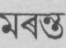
মৰন্ত
